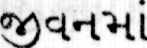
જીવનમાં
